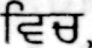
ਵਿਚ,
